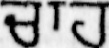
ਚਾਹ
